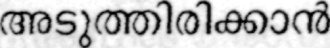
അടുത്തിരിക്കാന്‍
